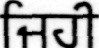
ਜਿਹੀ
